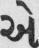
એ
